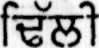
ਢਿੱਲੀ
